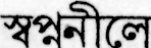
স্বপ্ননীলে
